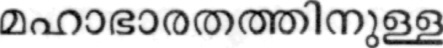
മഹാഭാരതത്തിനുള്ള
